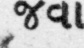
જવા
